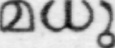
മധു
